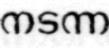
നടന്ന
